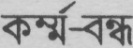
কৰ্ম্ম-বন্ধ
